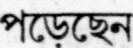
পড়েছেন
